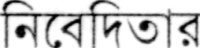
নিবেদিতার
